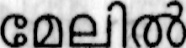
മേലില്‍
